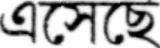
এসেছে
